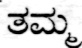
ತಮ್ಮ
